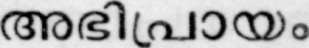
അഭിപ്രായം
